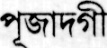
পূজাদগী
